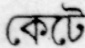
কেটে
